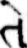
તે
